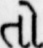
તો
